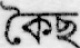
কৈছ
